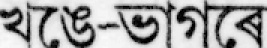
খঙে-ভাগৰে
